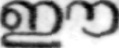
ഈ
